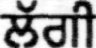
ਲੱਗੀ
